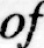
of
